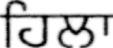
ਹਿਲਾ
